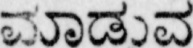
ಮಾಡುವ
